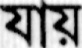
যায়
